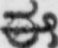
ಈ
